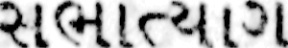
સભાત્યાગ
